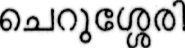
ചെറുശ്ശേരി
